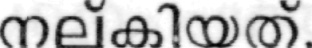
നല്കിയത്.
